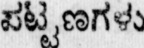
ಪಟ್ಟಣಗಳು
